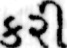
કરી
